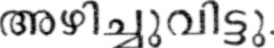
അഴിച്ചുവിട്ടു.
